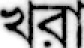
খরা
